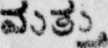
ಮತ್ತು
